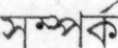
সম্পর্ক
